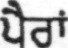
ਪੈਰਾਂ
